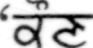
'ਕੌਣ
